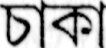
চাকা
